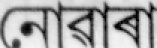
নোৱাৰা
